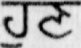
ਹੁਣ
